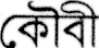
কৌবী
